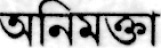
অনিমক্তা
